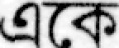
একে
